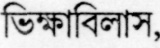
ভিক্ষাবিলাস,
